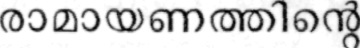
രാമായണത്തിന്റെ
